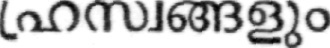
ഹ്രസ്വങ്ങളും
